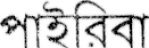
পাইরিবা
